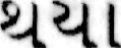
થયા
